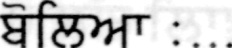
ਬੋਲਿਆ:...
